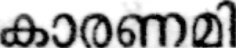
കാരണമി
